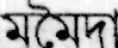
মমৈদা
